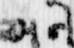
અને
